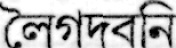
লৈগদবনি
